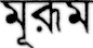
মূরূম
